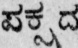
ಪಕ್ಷದ
